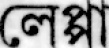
লেপ্পা
